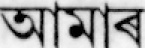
আমাৰ
